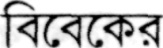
বিবেকের
